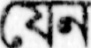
যেন
